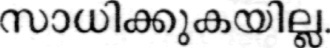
സാധിക്കുകയില്ല.
